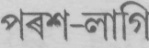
পৰশ-লাগি
